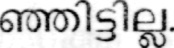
ഞ്ഞിട്ടില്ല.
